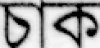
চাক
